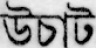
উচাট
